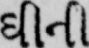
ઘીની
